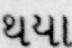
થયા
